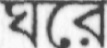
ঘরে
